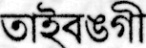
তাইবঙগী
